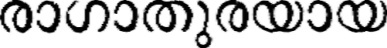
രാഗാതുരയായ
